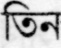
তিন
